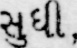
સુધી,
